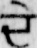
ਦੇ
